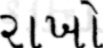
રાખો
